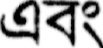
এবং
